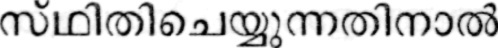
സ്ഥിതിചെയ്യുന്നതിനാല്‍
